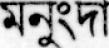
মনুংদা
